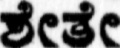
ಶೇತೇ
